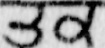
ਤਕ
